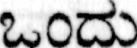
ಒಂದು
